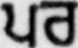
ਪਰ
